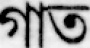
গাত
